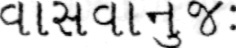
વાસવાનુજઃ
